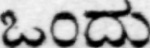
ಒಂದು
